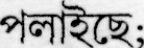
পলাইছে;
